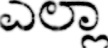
ಎಲ್ಲಾ
